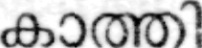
കാത്തി
